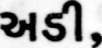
અડી,
